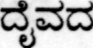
ದೈವದ
